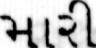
મારી
